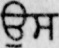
ਉਸ
